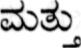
ಮತ್ತು
